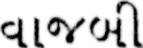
વાજબી
